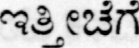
ಇತ್ತೀಚೆಗೆ
